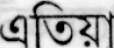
এতিয়া
